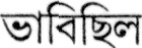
ভাবিছিল
